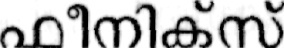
ഫീനിക്സ്
